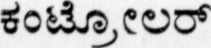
ಕಂಟ್ರೋಲರ್
